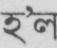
হ'ল
